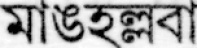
মাঙহল্লবা
